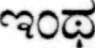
ಇಂಥ
